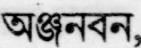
অঞ্জনবন,
